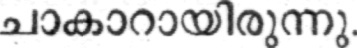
ചാകാറായിരുന്നു.
